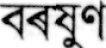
বৰষুণ
